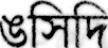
ঙসিদি
